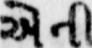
એની
